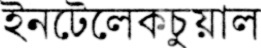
ইনটেলেকচুয়াল
